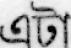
এটা
